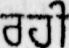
ਰਹੀ
